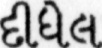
દીધેલ
